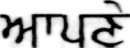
ਆਪਣੇ
